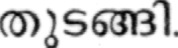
തുടങ്ങി.
